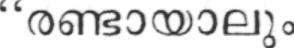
"രണ്ടായാലും
